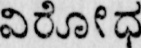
ವಿರೋಧ
